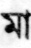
মা
